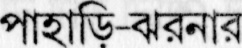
পাহাড়ি-ঝরনার
